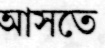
আসতে
